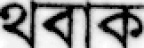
থবাক
